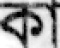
কা
